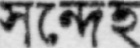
সন্দেহ
